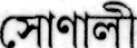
সোণালী
